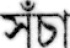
সঁচা
